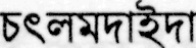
চৎলমদাইদা
